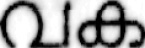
വക
